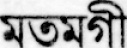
মতমগী
